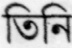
তিনি
